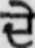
ਦੇ
